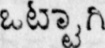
ಒಟ್ಟಾಗಿ
